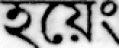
হয়েং
